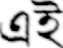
এই
